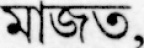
মাজত,
